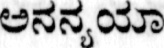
ಅನನ್ಯಯಾ
